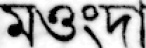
মওংদা
